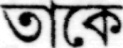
তাকে
